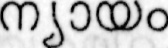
ന്യായം
